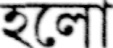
হলো
